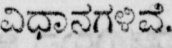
ವಿಧಾನಗಳಿವೆ.
